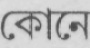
কোনে
